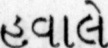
હવાલે
